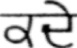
ਕਦੇ
